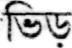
ভিড়
